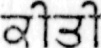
ਕੀਤੀ
